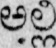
ಅಲ್ಲಿ
